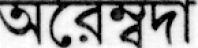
অরেম্বদা
